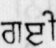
ਗਈ
